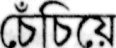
চেঁচিয়ে
